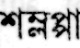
শম্লপ্পা
